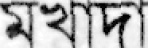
মখাদা
